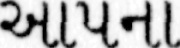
આપના
